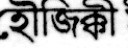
হৌজিক্কী
